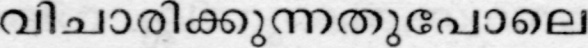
വിചാരിക്കുന്നതുപോലെ
